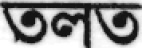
তলত
